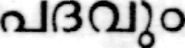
പദവും
